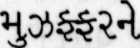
મુઝફ્ફરને
